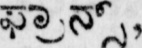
ಫ್ರಾನ್ಸ್,
